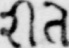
રીતે
